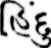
હિંદુ
